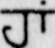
ਹਾਂ
